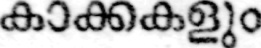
കാക്കകളും
